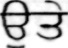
ਉਤੇ
